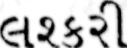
લશ્કરી
